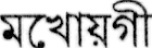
মখোয়গী
